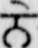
ਨੇ
